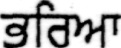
ਭਰਿਆ
